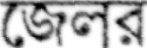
জেলর
